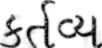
કર્તવ્ય
